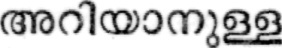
അറിയാനുള്ള
